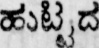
ಹುಟ್ಟಿದ
